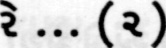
રે.......(૨)
